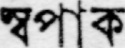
স্বপাক
